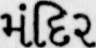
મંદિર
